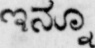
ಇನ್ನೂ
